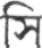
সি
